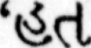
'હત
